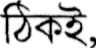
ঠিকই,
